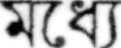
মধ্যে
